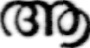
ആ
